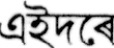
এইদৰে
